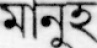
মানুহ
